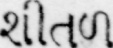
શીતળ
